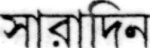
সারাদিন
